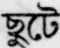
ছুটে
